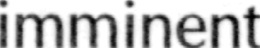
imminent
